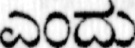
ಎಂದು
